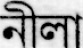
নীলা
